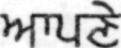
ਆਪਣੇ
